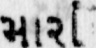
મારાં
